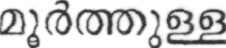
മൂര്‍ത്തുള്ള
